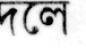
দলে
